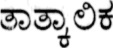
ತಾತ್ಕಾಲಿಕ
